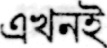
এখনই
